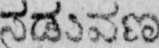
ನಡುವಣ
